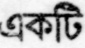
একটি
